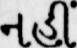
નહીં
